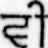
ਵੀ
